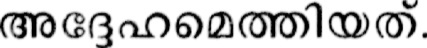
അദ്ദേഹമെത്തിയത്.
